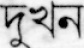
দুখন
